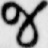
જ
